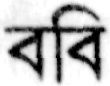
ববি
